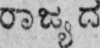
ರಾಜ್ಯದ
